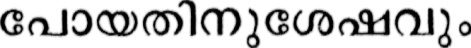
പോയതിനുശേഷവും
